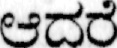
ಆದರೆ
